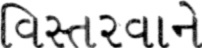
વિસ્તરવાને
